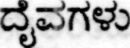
ದೈವಗಳು
